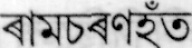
ৰামচৰণহঁত
